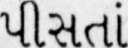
પીસતાં
